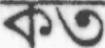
কত
